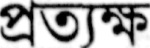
প্রত্যক্ষ
